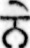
ਨੇ
